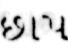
છાપ
